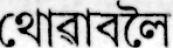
থোৱাবলৈ
